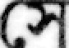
সে
